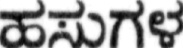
ಹಸುಗಳ
